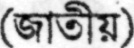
(জাতীয়)
